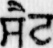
ਸੈਟ
